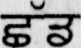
ਛੱਡ
